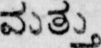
ಮತ್ತು
